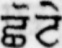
ਛੋਟੇ
